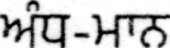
ਅੰਧ-ਮਾਨ
